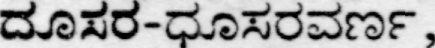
ದೂಸರ-ಧೂಸರವರ್ಣ,
